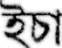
ইচা
